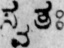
ಸ್ವತಃ
